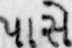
પાસે
